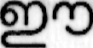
ഈ
